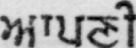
ਆਪਣੀ
